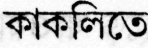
কাকলিতে
